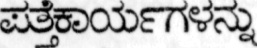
ಪತ್ತೆಕಾರ್ಯಗಳನ್ನು
